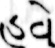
હવે
